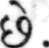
છે.
